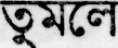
তুমলে
